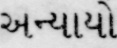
અન્યાયો
